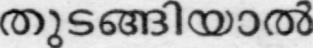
തുടങ്ങിയാല്‍
